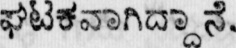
ಘಟಕವಾಗಿದ್ದಾನೆ.
